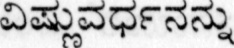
ವಿಷ್ಣುವರ್ಧನನ್ನು
